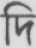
দি
